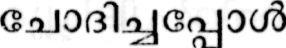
ചോദിച്ചപ്പോള്‍
